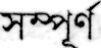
সম্পূৰ্ণ
